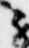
કે
